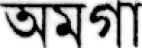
অমগা
